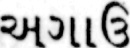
અગાઉ
